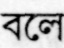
বলে
